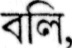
বলি,
